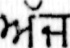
ਅੱਜ
